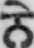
ਨੇ
